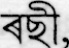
ৰছী,
